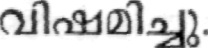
വിഷമിച്ചു.
